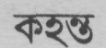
কহন্ত
